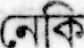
নেকি
